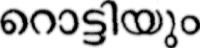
റൊട്ടിയും
